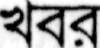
খবর
